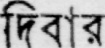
দিবার
